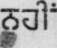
ਨਹੀਂ
